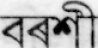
বৰশী
